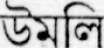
উমলি
